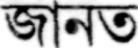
জানত
